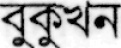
বুকুখন
